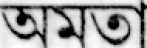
অমতা
